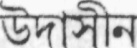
উদাসীন
